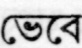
ভেবে
